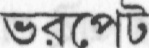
ভরপেট
